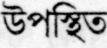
উপস্থিত
